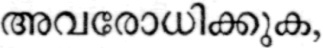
അവരോധിക്കുക,
